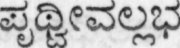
ಪೃಥ್ವೀವಲ್ಲಭ
